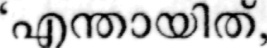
'എന്തായിത്,
